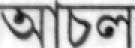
আচল
